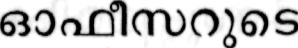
ഓഫീസറുടെ
